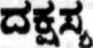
ದಕ್ಷಸ್ಯ
